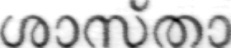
ശാസ്താ
